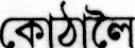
কোঠালৈ
